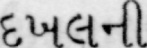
દખલની
